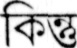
কিন্তু
